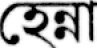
হেন্না
